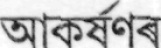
আকর্ষণৰ
